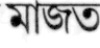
মাজত
